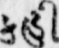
કહી
